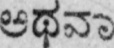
ಅಥವಾ
